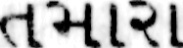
તમારા
